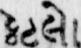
કેટલો
